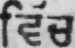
ਵਿੱਚ
